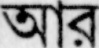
আর
